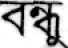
বন্ধু
